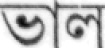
ভাল
